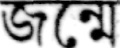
জন্মে
